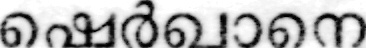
ഷെര്‍ഖാനെ
